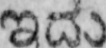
ಇದು
